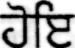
ਹੋਇ
